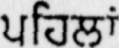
ਪਹਿਲਾਂ
